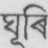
ঘূৰি
